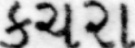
કચરા
